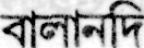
বালানদি
